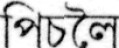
পিচলৈ
